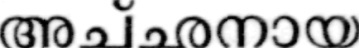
അച്ഛനായ
